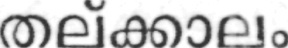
തല്ക്കാലം
